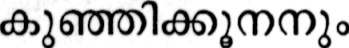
കുഞ്ഞിക്കൂനനും
